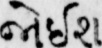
જોઈશ
